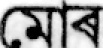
মোৰ
